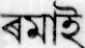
ৰমাই
